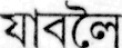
যাবলৈ
